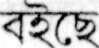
বইছে
